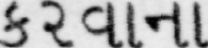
કરવાના
